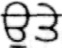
ਉਤੇ
